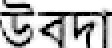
উবদা
